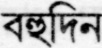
বহুদিন
